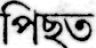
পিছত
